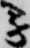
કે
